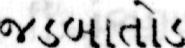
જડબાતોડ
